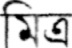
মিত্র
